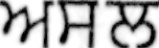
ਅਸਲ
